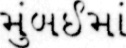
મુંબઈમાં
